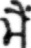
ਮੈਂ
